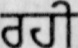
ਰਹੀ
